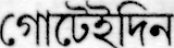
গোটেইদিন
